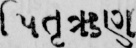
પિતૃઋણ
